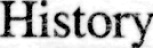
History
